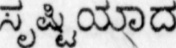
ಸೃಷ್ಟಿಯಾದ
